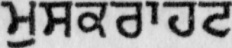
ਮੁਸਕਰਾਹਟ
